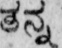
ತನ್ನ
